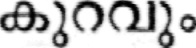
കുറവും
